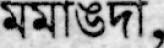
মমাঙদা,
